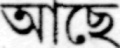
আছে
